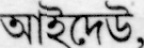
আইদেউ,
